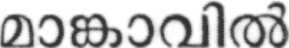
മാങ്കാവില്‍
